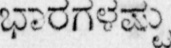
ಭಾರಗಳಷ್ಟು
